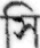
সি
